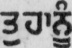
ਤੁਹਾਨੂੰ
